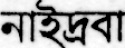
নাইদ্রবা
